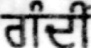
ਗੰਦੀ
